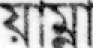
য়াম্না
